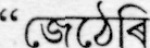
"জেঠেৰি
